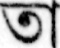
তা
